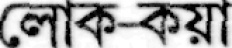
লোক-কয়া
